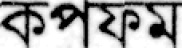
কপফম
